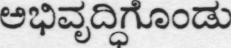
ಅಭಿವೃದ್ಧಿಗೊಂಡು
